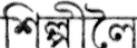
শিল্পীলৈ
